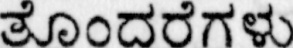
ತೊಂದರೆಗಳು
